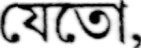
যেতো,
